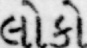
લોકો
